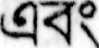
এবং
